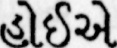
હોઈએ
